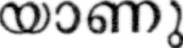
യാണു
